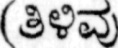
(ತಿಳಿವು
